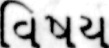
વિષય
